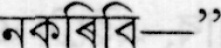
নকৰিবি-"
